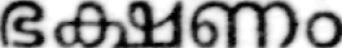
ഭക്ഷണം
